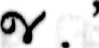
જ.'
